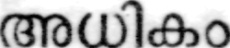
അധികം
